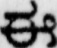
ಈ
